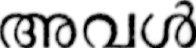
അവള്‍
